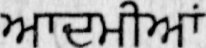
ਆਦਮੀਆਂ
